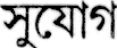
সুযোগ
